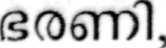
ഭരണി,
